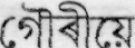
গৌৰীয়ে
